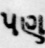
પણ
